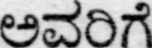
ಅವರಿಗೆ
